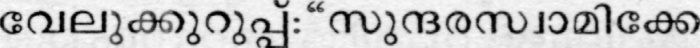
വേലുക്കുറുപ്പ്:"സുന്ദരസ്വാമിക്കേ
